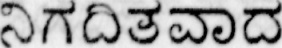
ನಿಗದಿತವಾದ
